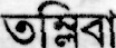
তম্লিবা
